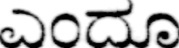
ಎಂದೂ
